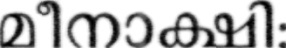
മീനാക്ഷി:
